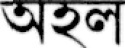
অহল
